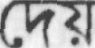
দেয়
